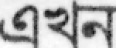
এখন
